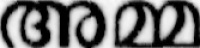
അമ്മ
